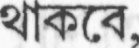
থাকবে,
